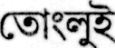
তোংলুই
